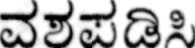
ವಶಪಡಿಸಿ
